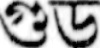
গুড
